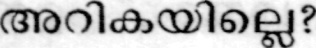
അറികയില്ലെ?
